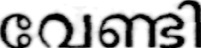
വേണ്ടി
